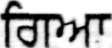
ਗਿਆ
